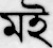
মই
